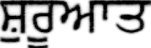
ਸ਼ੁਰੂਆਤ
